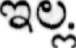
ಇಲ್ಲ.
